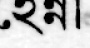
হেন্না
